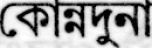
কোন্নদুনা
